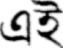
এই
